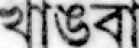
খাঙবা
